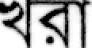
খরা
